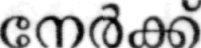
നേര്‍ക്ക്
